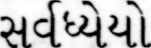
સર્વધ્યેયો
